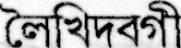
লৈখিদবগী
